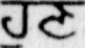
ਹੁਣ
